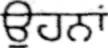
ਉਹਨਾਂ
